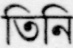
তিনি
